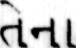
તેના
